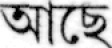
আছে
